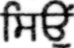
ਸਿਉਂ
